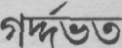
গৰ্দ্দভত
